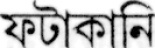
ফটাকানি
